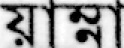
য়াম্না
